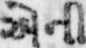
એની
